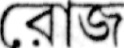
রোজ
